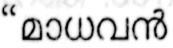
"മാധവന്‍
